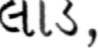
લાડ,
